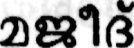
മജീദ്
